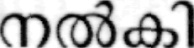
നല്‍കി
